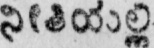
ನೀತಿಯಲ್ಲಿ
